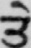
ਤੇ
